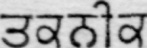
ਤਕਨੀਕ
